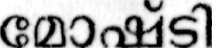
മോഷ്ടി
